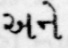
અને
